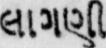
લાગણી
